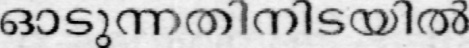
ഓടുന്നതിനിടയില്‍
